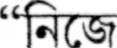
“নিজে
